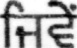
ਜਿਵੇਂ
